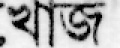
খোজ
